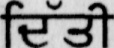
ਦਿੱਤੀ
